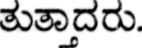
ತುತ್ತಾದರು.
